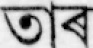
তাৰ
